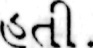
હતી.
